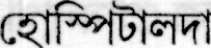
হোস্পিটালদা
